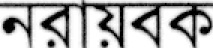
নরায়বক
